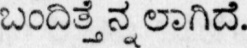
ಬಂದಿತ್ತೆನ್ನಲಾಗಿದೆ.
